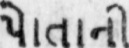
પોતાની
